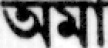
অমা
